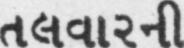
તલવારની
